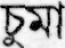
চুমা
